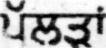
ਪੱਲੜਾਂ
